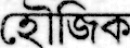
হৌজিক
